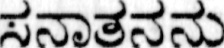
ಸನಾತನನು
